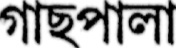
গাছপালা
